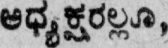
ಅಧ್ಯಕ್ಷರಲ್ಲೂ,
